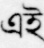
এই
